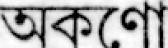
অকণো
